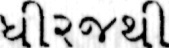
ધીરજથી
